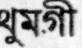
থুমগী
